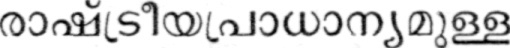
രാഷ്ട്രീയപ്രാധാന്യമുള്ള
